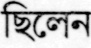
ছিলেন
